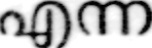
എന്ന
